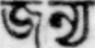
জন্য
